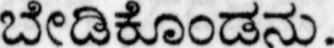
ಬೇಡಿಕೊಂಡನು.
